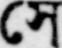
সে
